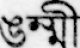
ঙম্মী
